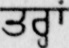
ਤਰ੍ਹਾਂ
